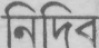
নিদিব
